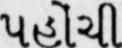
પહોંચી
